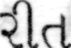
રીત
